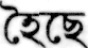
হৈছে
